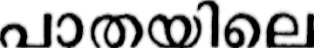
പാതയിലെ
